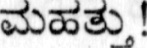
ಮಹತ್ತು!
